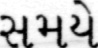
સમયે
